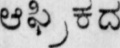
ಆಫ್ರಿಕದ
